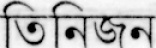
তিনিজন
